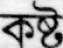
কষ্ট
